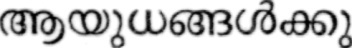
ആയുധങ്ങള്‍ക്കു
